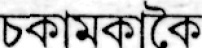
চকামকাকৈ
